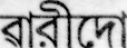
ৱারীদো
